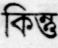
কিন্তু
